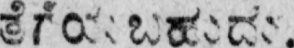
ತೆಗೆಯಬಹುದು.
